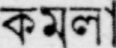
কমলা
